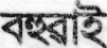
বহুৱাই
